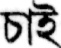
চাই
